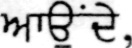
ਆਉਂਦੇ,
